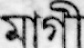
মাগী
